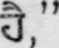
ਹੈ,''
